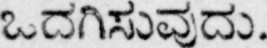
ಒದಗಿಸುವುದು.
